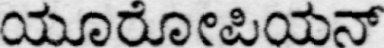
ಯೂರೋಪಿಯನ್
